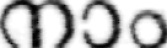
നാം
